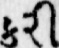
કરી
